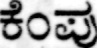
ಕೆಂಪು
